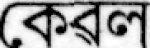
কেৱল
